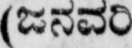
(ಜನವರಿ
